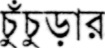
চুঁচুড়ার
